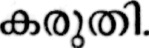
കരുതി.
